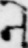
ને
